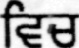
ਵਿਚ
